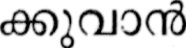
ക്കുവാന്‍
